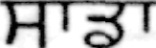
ਸਾਡਾ
